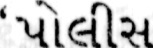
'પોલીસ
